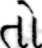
તો
